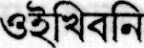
ওইখিবনি
